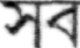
সব
